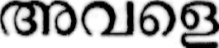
അവളെ
